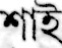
শাই
